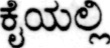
ಕೈಯಲ್ಲಿ
